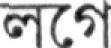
লগে
